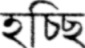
হচ্ছি
